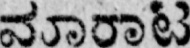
ಮಾರಾಟ
